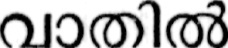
വാതില്‍
